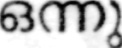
ഒന്നു
